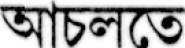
আচলতে
